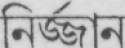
নিৰ্জ্জান
